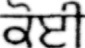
ਕੋਈ
